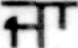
ਜਾ
